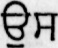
ਉਸ
